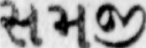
સમજી
